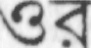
ওর
